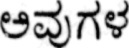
ಅವುಗಳ
